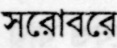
সরোবরে
